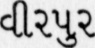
વીરપુર
